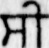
ਸੀ
